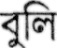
বুলি
